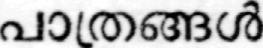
പാത്രങ്ങള്‍
